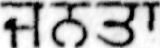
ਜਨਤਾ
